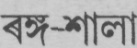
ৰঙ্গ-শালা
